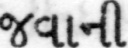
જવાની
